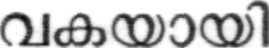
വകയായി
